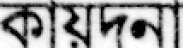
কায়দনা
